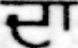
ਦਾ
